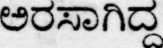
ಅರಸಾಗಿದ್ದ
